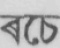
ৰচে
